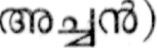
അച്ചന്‍)
